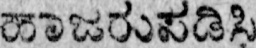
ಹಾಜರುಪಡಿಸಿ
